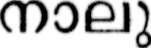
നാലു
